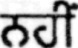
ਨਹੀਂ
